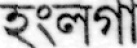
হংলগা
